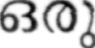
ഒരു
